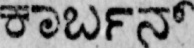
ಕಾರ್ಬನ್
